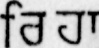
ਰਿਹਾ
